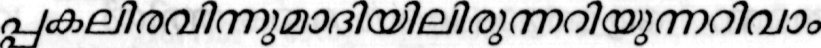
പ്പകലിരവിന്നുമാദിയിലിരുന്നറിയുന്നറിവാം
